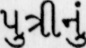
પુત્રીનું
